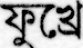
ফুখ্রে
